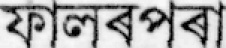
ফালৰপৰা
